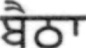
ਬੈਠਾ
